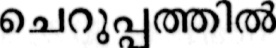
ചെറുപ്പത്തില്‍
